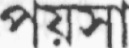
পয়সা
